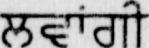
ਲਵਾਂਗੀ
